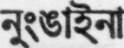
নুংঙাইনা
